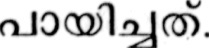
പായിച്ചത്.
